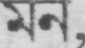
মন,
